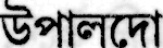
উপালদো
